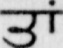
ਤਾਂ
